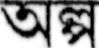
অল্প
